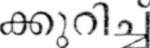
ക്കുറിച്ച്
